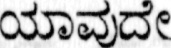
ಯಾವುದೇ
